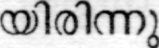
യിരിന്നു
